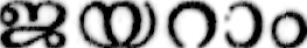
ജയറാം
